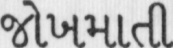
જોખમાતી
